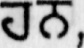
ਹਨ,
